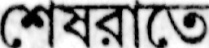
শেষরাতে
